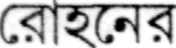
রোহনের
